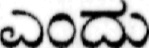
ಎಂದು
